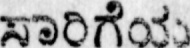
ಸಾರಿಗೆಯ
